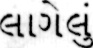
લાગેલું
